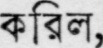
করিল,
